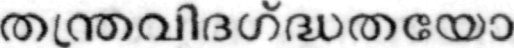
തന്ത്രവിദഗ്ദ്ധതയോ
